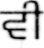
ਵੀ
